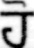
ਹੋ
